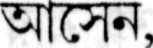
আসেন,
